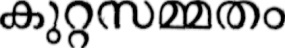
കുറ്റസമ്മതം
